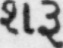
શરૂ
